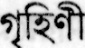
গৃহিণী
